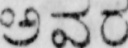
ಅವರ
